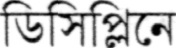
ডিসিপ্লিনে
